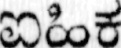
ಐಹಿಕ
